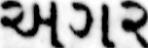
અગર
